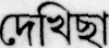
দেখিছা
